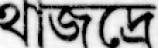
থাজদ্রে
